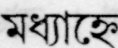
মধ্যাহ্নে
